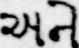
અને
